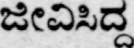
ಜೀವಿಸಿದ್ದ
